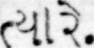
ત્યારે.
